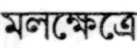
মলক্ষেত্রে
